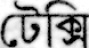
টেক্সি
